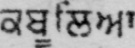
ਕਬੂਲਿਆ
